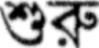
শুরু
